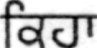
ਕਿਹਾ
